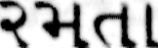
રમતા
